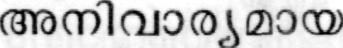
അനിവാര്യമായ
